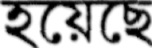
হয়েছে
